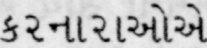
કરનારાઓએ
